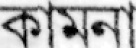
কামনা
